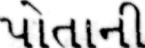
પોતાની
